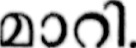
മാറി.
